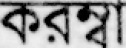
করম্বা
